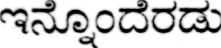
ಇನ್ನೊಂದೆರಡು
